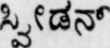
ಸ್ವೀಡನ್
